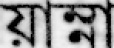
য়াম্না
